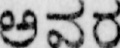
ಅವರ
